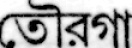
তৌরগা
